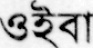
ওইবা
